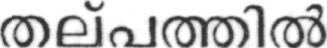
തല്പത്തില്‍
